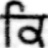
ਕਿ
